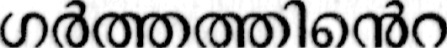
ഗര്‍ത്തത്തിന്റെ
